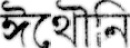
ঈথৌনি
